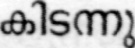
കിടന്നു
